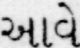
આવે
